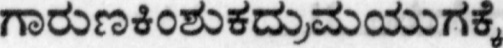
ಗಾರುಣಕಿಂಶುಕದ್ರುಮಯುಗಕ್ಕೆ
